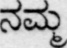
ನಮ್ಮ
